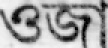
ওজা
